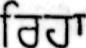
ਰਿਹਾ
